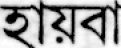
হায়বা
